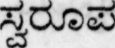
ಸ್ವರೂಪ
